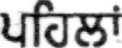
ਪਹਿਲਾਂ
